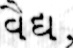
વૈધ,
